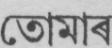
তোমাৰ
